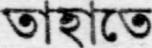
তাহাতে
